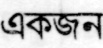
একজন
